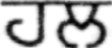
ਹਲ
